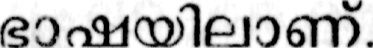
ഭാഷയിലാണ്.
